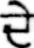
ਦੇ
